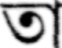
তা
